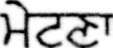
ਮੇਟਣਾ
